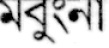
মবুংনা
